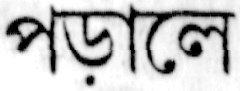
পড়ালে
